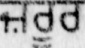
ਜ਼ਰੂਰ
